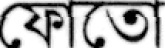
ফোতো
